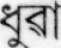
ধুৱা
